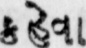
કહેવા
